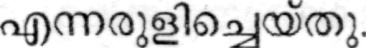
എന്നരുളിച്ചെയ്തു.
